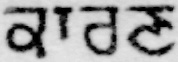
ਕਾਰਣ
